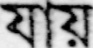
যায়
